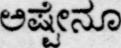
ಅಷ್ಟೇನೂ
